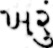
ખરું
